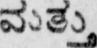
ಮತ್ತು
